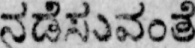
ನಡೆಸುವಂತೆ
